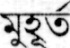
মুহূর্ত
